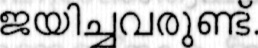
ജയിച്ചവരുണ്ട്.
